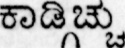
ಕಾಡ್ಗಿಚ್ಚು
